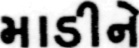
માડીને
